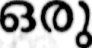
ഒരു
